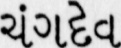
ચંગદેવ
